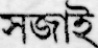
সজাই
